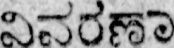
ವಿವರಣಾ
